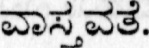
ವಾಸ್ತವತೆ.
